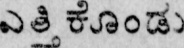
ಎತ್ತಿಕೊಂಡು
